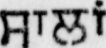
ਸਾਲਾਂ
